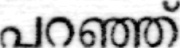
പറഞ്ഞ്
